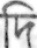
দি
